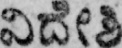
ವಿದೇಶಿ
